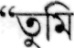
"তুমি
